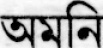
অমনি
